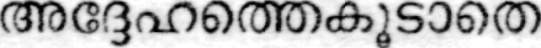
അദ്ദേഹത്തെകൂടാതെ
